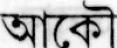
আকৌ
